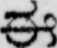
ಈ
